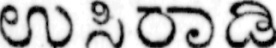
ಉಸಿರಾಡಿ
